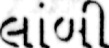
લાંબી
